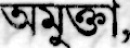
অমুক্তা,
